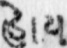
હોય
